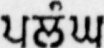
ਪਲੰਘ
